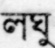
লঘু
